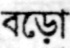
বড়ো
